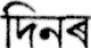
দিনৰ
